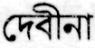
দেবীনা
